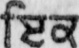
ਇਕ
